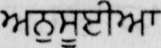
ਅਨੁਸੂਈਆ
